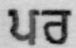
ਪਰ
